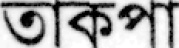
তাকপা
